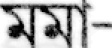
মমা-
